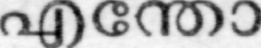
എന്തോ
